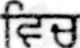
ਵਿਚ
